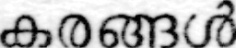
കരങ്ങള്‍
